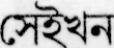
সেইখন
